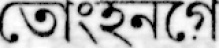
তোংহনগে
